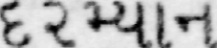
દરમ્યાન
